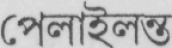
পেলাইলন্ত
